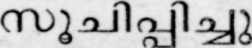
സൂചിപ്പിച്ചു
